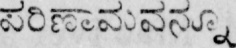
ಪರಿಣಾಮವನ್ನೂ
